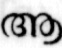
ആ
